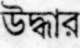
উদ্ধার
